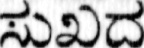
ಸುಖದ
